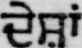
ਦੇਸ਼ਾਂ
